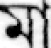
মা
